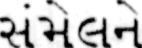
સંમેલને
